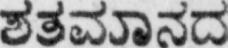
ಶತಮಾನದ
